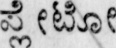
ಪ್ಲೇಟೋ
